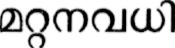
മറ്റനവധി
